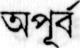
অপূর্ব
